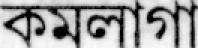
কমলাগা
